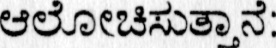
ಆಲೋಚಿಸುತ್ತಾನೆ:
